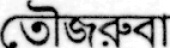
তৌজরুবা
